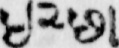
ઈચ્છા
